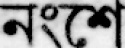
নংশে
